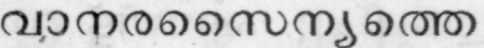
വാനരസൈന്യത്തെ
